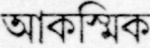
আকস্মিক
